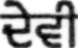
ਦੇਵੀ
